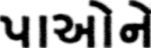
પાઓને
